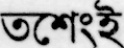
তশেংই
